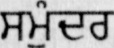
ਸਮੁੰਦਰ
